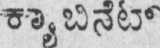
ಕ್ಯಾಬಿನೆಟ್
